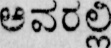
ಅವರಲ್ಲಿ
